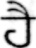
ਹੈ
